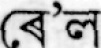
ৰে'ল
